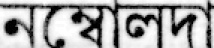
নম্বোলদা
